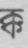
ক্ক
